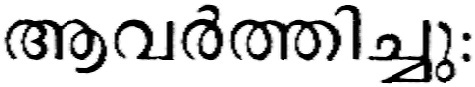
ആവര്‍ത്തിച്ചു:
